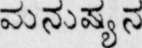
ಮನುಷ್ಯನ
